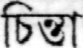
চিন্তা
